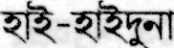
হাই-হাইদুনা
